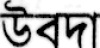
উবদা
